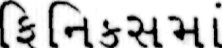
ફિનિક્સમાં
